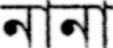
নানা
